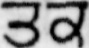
ਤਕ
